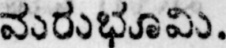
ಮರುಭೂಮಿ.
